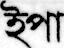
ইপা
